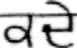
ਕਦੇ
